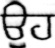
ਉਹ
